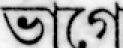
ভাগে
